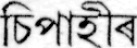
চিপাহীৰ
